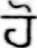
ਹੋ
